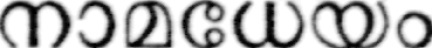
നാമധേയം
